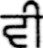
ਵੀ
